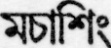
মচাশিং
